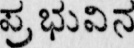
ಪ್ರಭುವಿನ
